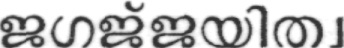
ജഗജ്ജയിത്വ
